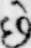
છે
